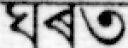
ঘৰত
